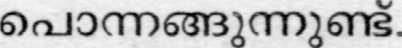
പൊന്നങ്ങുന്നുണ്ട്.
